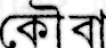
কৌবা
